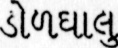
ડોળઘાલુ
